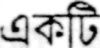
একটি
